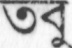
তবু
